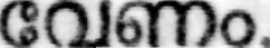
വേണം.
